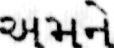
અમને
